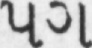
પગ
